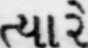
ત્યારે
